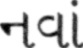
નવાં
